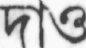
দাও
